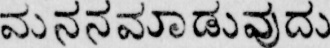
ಮನನಮಾಡುವುದು
